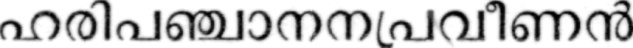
ഹരിപഞ്ചാനനപ്രവീണന്‍
